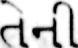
તેની
